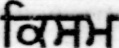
ਕਿਸਮ
